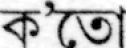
ক'তো
